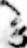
કે
